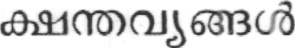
ക്ഷന്തവ്യങ്ങള്‍
